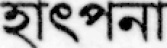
হাৎপনা
